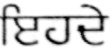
ਇਹਦੇ
